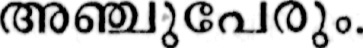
അഞ്ചുപേരും.
